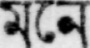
মনে
